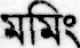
মমিং
